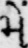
મેં
